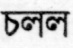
চলল
